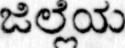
ಜಿಲ್ಲೆಯ
